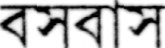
বসবাস
